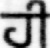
ਹੀ
